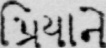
પ્રિયાને
